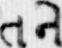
તને
